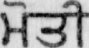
ਮੋਤੀ
